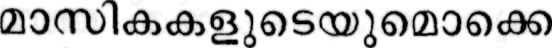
മാസികകളുടെയുമൊക്കെ
